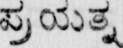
ಪ್ರಯತ್ನ
